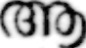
ആ
